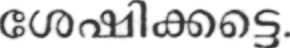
ശേഷിക്കട്ടെ.
